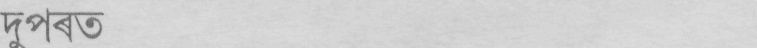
দুপৰত
